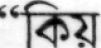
"কিয়
